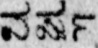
ವರ್ಷ
